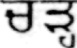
ਚੜ੍ਹ
